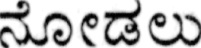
ನೋಡಲು
